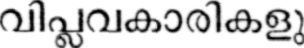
വിപ്ലവകാരികളു
